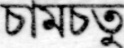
চামচতু
